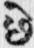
છે
